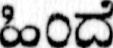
ಹಿಂದೆ
